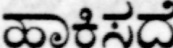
ಹಾಕಿಸದೆ
